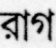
রাগ
